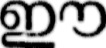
ഈ
